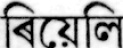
ৰিয়েলি
